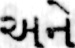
અને
